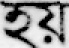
হয়
